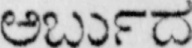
ಅರ್ಬುದ
